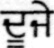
ਦੂਜੇ
